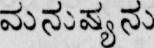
ಮನುಷ್ಯನು
